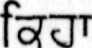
ਕਿਹਾ
